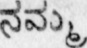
ನಮ್ಮ
